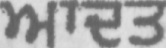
ਆਦਤ
